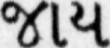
જાય
